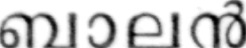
ബാലന്‍
